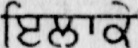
ਇਲਾਕੇ
